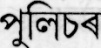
পুলিচৰ
